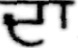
ਦਾ
